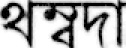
থম্বদা
